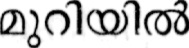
മുറിയില്‍
